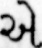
એ
